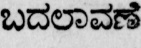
ಬದಲಾವಣೆ
